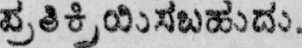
ಪ್ರತಿಕ್ರಿಯಿಸಬಹುದು.
